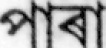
পাৰা
